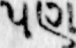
પણ
